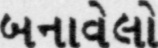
બનાવેલો
